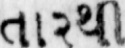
તારથી
